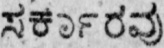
ಸರ್ಕಾರವು
